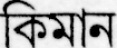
কিমান
